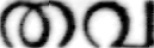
തവ
